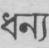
ধন্য
